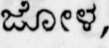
ಜೋಳ,
